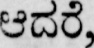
ಆದರೆ,
